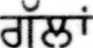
ਗੱਲਾਂ
